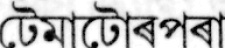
টেমাটোৰপৰা
